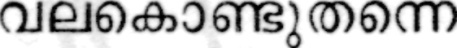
വലകൊണ്ടുതന്നെ
